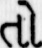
તો
